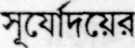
সূর্যোদয়ের
